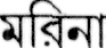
মরিনা
